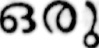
ഒരു
